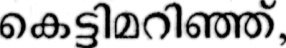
കെട്ടിമറിഞ്ഞ്,
